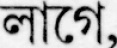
লাগে,
